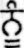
ਨੂੰ
